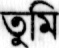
তুমি
